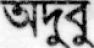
অদুবু
